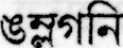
ঙম্লগনি
